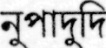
নুপাদুদি
